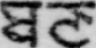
ਬਣ
